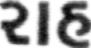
રાહ
